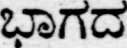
ಭಾಗದ
